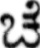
ಚೆ
